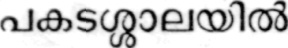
പകടശ്ശാലയില്‍
